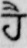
ਹੈ
